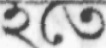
হতে
